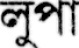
লুপা
